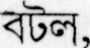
বটল,
